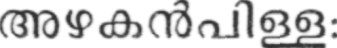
അഴകന്‍പിള്ള:
